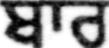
ਬਾਰ
